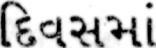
દિવસમાં
